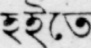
হইতে
